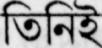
তিনিই
